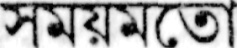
সময়মতো
